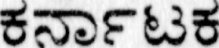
ಕರ್ನಾಟಕ
